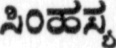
ಸಿಂಹಸ್ಯ
